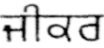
ਜੀਕਰ
